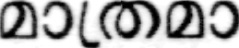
മാത്രമാ
